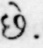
છે.
